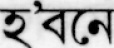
হ'বনে
